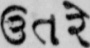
ઉતરે
